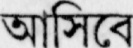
আসিবে
